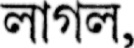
লাগল,
